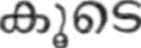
കൂടെ
